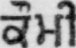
ਕੌਮੀ
